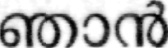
ഞാന്‍
